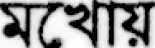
মখোয়
